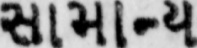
સામાન્ય
